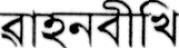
ৱাহনবীখি
